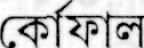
র্কোফাল
